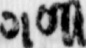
ગળી
